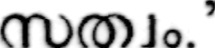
സത്വം.’
